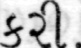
કરી.
